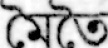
মৈতৈ
